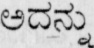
ಅದನ್ನು
